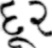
દૂર
